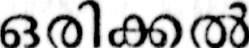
ഒരിക്കല്‍
